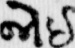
જોઈ
